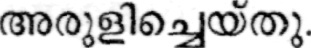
അരുളിച്ചെയ്തു.
